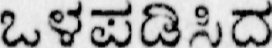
ಒಳಪಡಿಸಿದ
